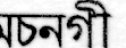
মচনগী
